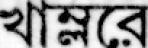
খাম্লরে
